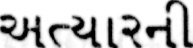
અત્યારની
